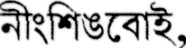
নীংশিঙবোই,
